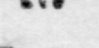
નથી.
